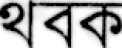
থবক
